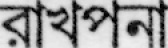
রাখপনা
